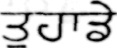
ਤੁਹਾਡੇ
